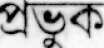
প্রভুক
